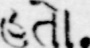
હતો.
